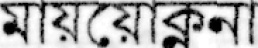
মায়য়োক্ননা
